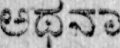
ಅಥವಾ
